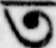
ত
